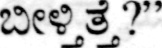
ಬೀಳ್ತಿತ್ತೆ?"
